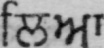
ਲਿਆ
